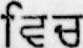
ਵਿਚ
